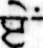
ਏਂ
